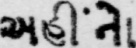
અહીંનો
